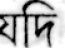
যদি
